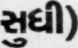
સુધી)
